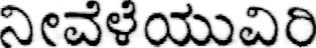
ನೀವೆಳೆಯುವಿರಿ
